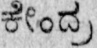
ಕೇಂದ್ರ
